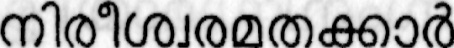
നിരീശ്വരമതക്കാര്‍
